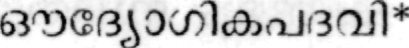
ഔദ്യോഗികപദവി*
